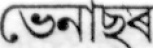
ভেনাছৰ
